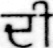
ਦੀ
